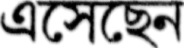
এসেছেন
